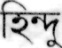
হিন্দু
